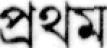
প্রথম
